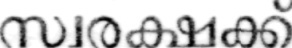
സ്വരക്ഷക്ക്
